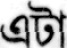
এটা
